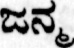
ಜನ್ಮ
